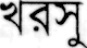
খরসু
